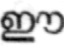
ഈ
